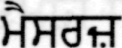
ਮੈਸਰਜ਼
